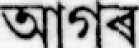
আগৰ
